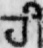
ਹੀ
